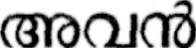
അവന്‍
